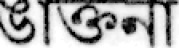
ঙাক্তনা
